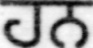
ਹਨ
